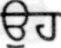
ਉਹ
